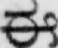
ಈ
